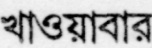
খাওয়াবার
